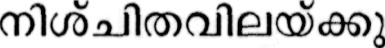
നിശ്ചിതവിലയ്ക്കു
